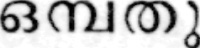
ഒമ്പതു
